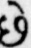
છે
